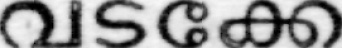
വടക്കേ
